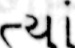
ત્યાં
